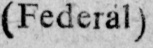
(Federal)
